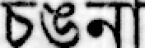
চঙনা
